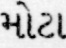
મોટા
